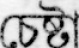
চেষ্টা
